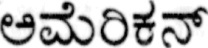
ಅಮೆರಿಕನ್
